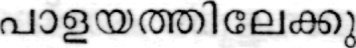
പാളയത്തിലേക്കു
